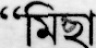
"মিছা
